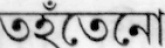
তহঁতেনো
